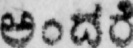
ಅಂದರೆ
